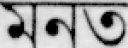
মনত
